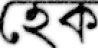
হেক
